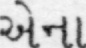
એના
